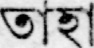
তাহা
